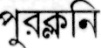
পুরক্লনি
